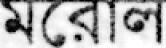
মরোল
